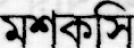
মশকসি
